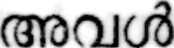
അവള്‍
